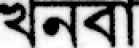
খনবা
